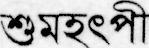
শুমহৎপী
